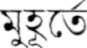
মুহূর্তে
